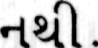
નથી.
